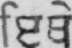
ਇਥੇ
